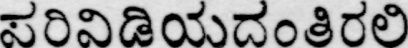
ಪರಿವಿಡಿಯದಂತಿರಲಿ
